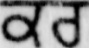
ਕਰ
